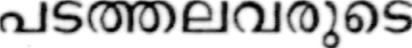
പടത്തലവരുടെ
